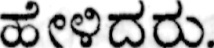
ಹೇಳಿದರು.
